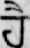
ਹੈ
